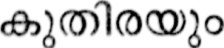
കുതിരയും
